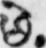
છે.
